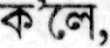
ক'লে,
